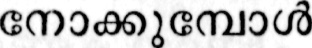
നോക്കുമ്പോള്‍
